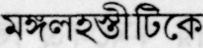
মঙ্গলহস্তীটিকে
